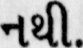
નથી.
